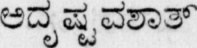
ಅದೃಷ್ಟವಶಾತ್
